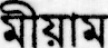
মীয়াম
